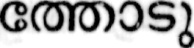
ത്തോടു
